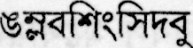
ঙম্লবশিংসিদবু
